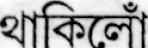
থাকিলোঁ
